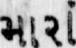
મારાં
